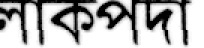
লাকপদা
